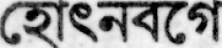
হোৎনবগে
